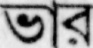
ভার
